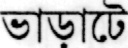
ভাড়াটে
